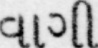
વાગી
